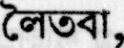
লৈতবা,
